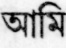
আমি
